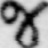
જ
